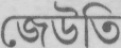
জেউতি
